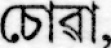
চোৱা,
